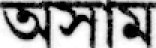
অসাম
